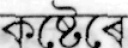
কষ্টেৰে
